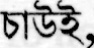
চাউই,
